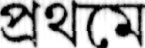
প্রথমে
